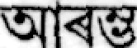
আৰম্ভ
